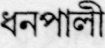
ধনপালী
